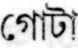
গোটা
